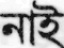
নাই
